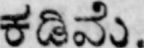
ಕಡಿಮೆ.
